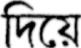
দিয়ে
